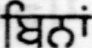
ਬਿਨਾਂ
